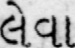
લેવા
